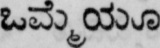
ಒಮ್ಮೆಯೂ
